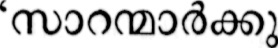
'സാറന്മാര്‍ക്കു
